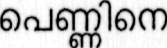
പെണ്ണിനെ
